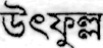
উৎফুল্ল
